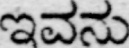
ಇವನು
